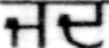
ਜਦ
